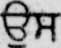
ਉਸ
